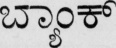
ಬ್ಯಾಂಕ್
